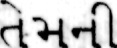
તેમની
